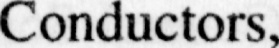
Conductors,
